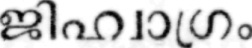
ജിഹ്വാഗ്രം
